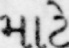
માટે
